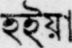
হইয়া
